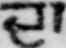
ਦਾ
